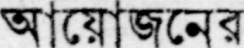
আয়োজনের
